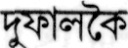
দুফালকৈ
